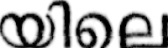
യിലെ
